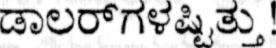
ಡಾಲರ್‌ಗಳಷ್ಟಿತ್ತು!
